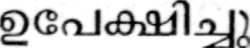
ഉപേക്ഷിച്ചു
